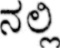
ನಲ್ಲಿ
